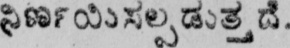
ನಿರ್ಣಯಿಸಲ್ಪಡುತ್ತದೆ.
